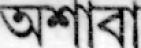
অশাবা
